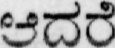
ಆದರೆ
